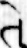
તે
